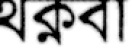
থক্নবা
